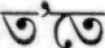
ত'তে
